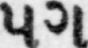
પગ
